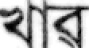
খাৱ
